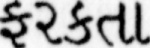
ફરકતા
